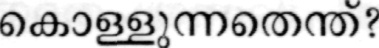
കൊള്ളുന്നതെന്ത്?
